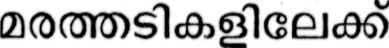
മരത്തടികളിലേക്ക്
